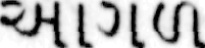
આગળ
